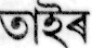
তাইৰ
